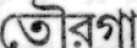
তৌরগা
